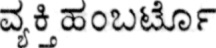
ವ್ಯಕ್ತಿಹಂಬರ್ಟೊ
